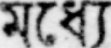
মধ্যে
